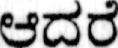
ಆದರೆ
